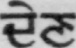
ਦੇਣ
